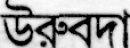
উরুবদা
